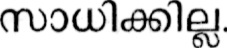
സാധിക്കില്ല.
